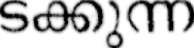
ടക്കുന്ന
